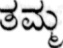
ತಮ್ಮ
